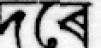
দৰে
